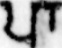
ਪਾ
